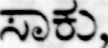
ಸಾಕು,
